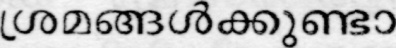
ശ്രമങ്ങള്‍ക്കുണ്ടാ
